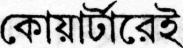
কোয়ার্টারেই
